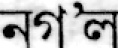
নগ'ল
